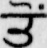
ਤੋਂ
